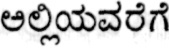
ಅಲ್ಲಿಯವರೆಗೆ
